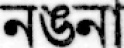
নঙনা
